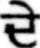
ਦੇ
